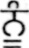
ਨੂੰ
